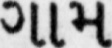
ગામ
